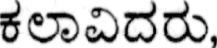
ಕಲಾವಿದರು,
